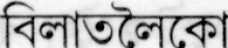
বিলাতলৈকো
